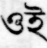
ওই
